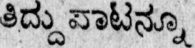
ತಿದ್ದುಪಾಟನ್ನೂ
